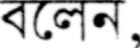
বলেন,
